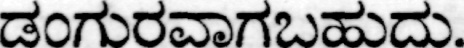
ಡಂಗುರವಾಗಬಹುದು.
